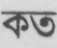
কত
